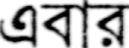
এবার
